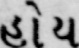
હોય
